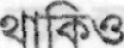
থাকিও
